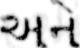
અને
